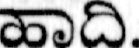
ಹಾದಿ.
